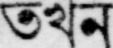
তখন
